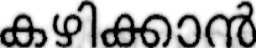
കഴിക്കാന്‍
